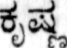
ಕೃಷ್ಣ
